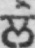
ਲੈ
